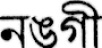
নঙগী
